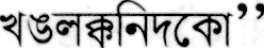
খঙলক্কনিদকো”
